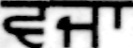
ਵਜਾ
